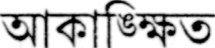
আকাঙ্ক্ষিত
